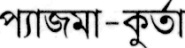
প্যাজমা-কুর্তা
